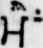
ਮੈਂ
